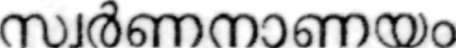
സ്വര്‍ണനാണയം
